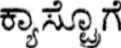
ಕ್ಯಾಸ್ಟ್ರೂಗೆ
